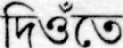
দিওঁতে
